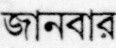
জানবার
